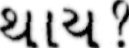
થાય?
